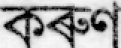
কৰুণ
